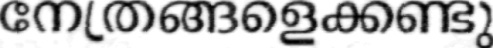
നേത്രങ്ങളെക്കണ്ടു
